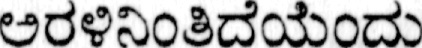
ಅರಳಿನಿಂತಿದೆಯೆಂದು
